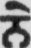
ਨੇ
